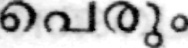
പെരും
